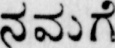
ನಮಗೆ
